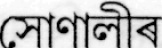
সোণালীৰ
